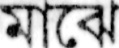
মাঝে
